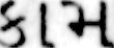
કામ
